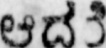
ಆದರೆ
